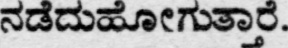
ನಡೆದುಹೋಗುತ್ತಾರೆ.
